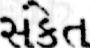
સંકેત
